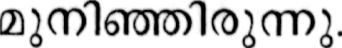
മുനിഞ്ഞിരുന്നു.
